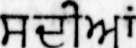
ਸਦੀਆਂ
